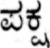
ಪಕ್ಷ
